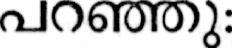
പറഞ്ഞു:
